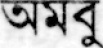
অমবু
